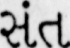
સંત
